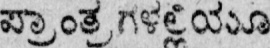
ಪ್ರಾಂತ್ರಗಳಲ್ಲಿಯೂ
